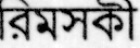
রিমসকী
